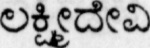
ಲಕ್ಷ್ಮೀದೇವಿ
